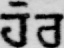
ਹੋਰ
